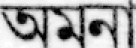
অমনা
